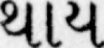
થાય
